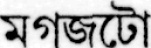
মগজটো
